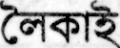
লৈকাই
